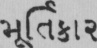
મૂર્તિકાર
